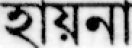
হায়না
